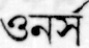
ওনর্স
